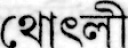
থোৎলী
